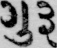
ગુરૂ
